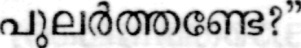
പുലര്‍ത്തണ്ടേ?”
